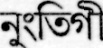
নুংতিগী
